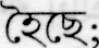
হৈছে;
